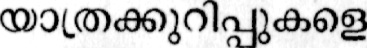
യാത്രക്കുറിപ്പുകളെ
